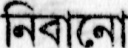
নিবানো
